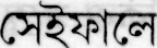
সেইফালে
